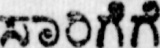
ಸಾರಿಗೆಗೆ
